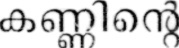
കണ്ണിന്റെ
